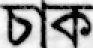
চাক
